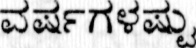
ವರ್ಷಗಳಷ್ಟು
